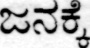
ಜನಕ್ಕೆ
